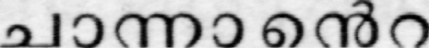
ചാന്നാന്റെ
